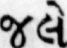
જલે
